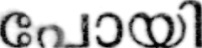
പോയി
